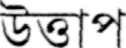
উত্তাপ
